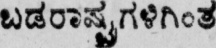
ಬಡರಾಷ್ಟ್ರಗಳಿಗಿಂತ
